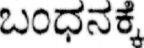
ಬಂಧನಕ್ಕೆ
